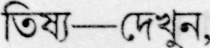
তিষ্য–দেখুন,
